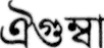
ঐগুম্বা
